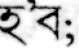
হ'ব;
